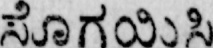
ಸೊಗಯಿಸಿ
